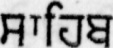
ਸਾਹਿਬ
